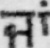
ਜਾਂ
